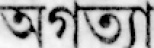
অগত্যা
